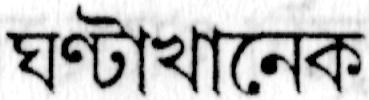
ঘন্টাখানেক
